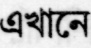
এখানে
